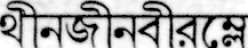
থীনজীনবীরম্লে
